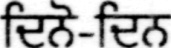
ਦਿਨੋ-ਦਿਨ
